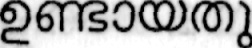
ഉണ്ടായതു
